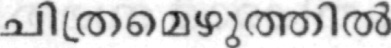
ചിത്രമെഴുത്തില്‍
